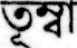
তূম্বা
